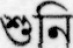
শুনি
